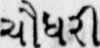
ચૌધરી
